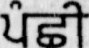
ਪੰਛੀ
